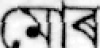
মোৰ
